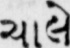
ચાલે
